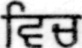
ਵਿਚ
